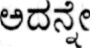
ಅದನ್ನೇ
